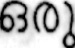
ഒരു
